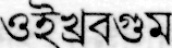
ওইখ্রবগুম
